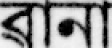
ৱানা
